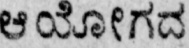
ಆಯೋಗದ
